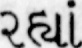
રહ્યાં
